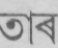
তাৰ
